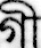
গী
